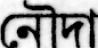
নৌদা
